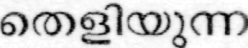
തെളിയുന്ന
